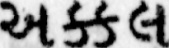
અક્કલ
